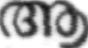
ആ
